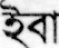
ইবা
